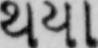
થયા
